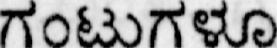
ಗಂಟುಗಳೂ
